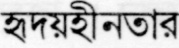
হৃদয়হীনতার
